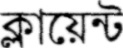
ক্লায়েন্ট
